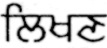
ਲਿਖਣ
